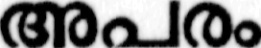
അപരം
